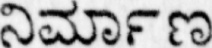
ನಿರ್ಮಾಣ
